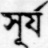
সূর্য
